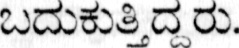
ಬದುಕುತ್ತಿದ್ದರು.
